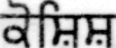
ਕੋਸ਼ਿਸ਼
